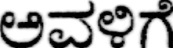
ಅವಳಿಗೆ
